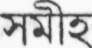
সমীহ
